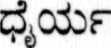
ಧೈರ್ಯ
